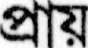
প্রায়
